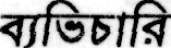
ব্যভিচারি
